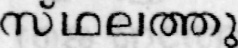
സ്ഥലത്തു
